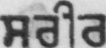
ਸਰੀਰ
